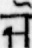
ਜੋ
